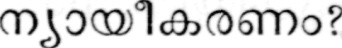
ന്യായീകരണം?
